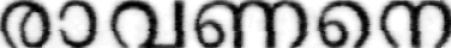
രാവണനെ
